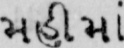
મહીમાં
